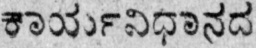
ಕಾರ್ಯವಿಧಾನದ
